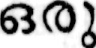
ഒരു
